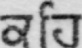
ਕਹਿ
